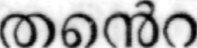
തന്റെ
